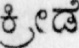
ಕ್ರೀಡೆ
